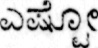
ಎಷ್ಟೋ
